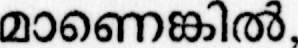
മാണെങ്കില്‍,
